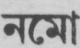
নমো
